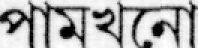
পামখনো
